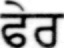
ਫੇਰ
